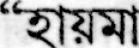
“হায়মা
